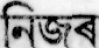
নিজৰ
